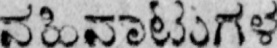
ವಹಿವಾಟುಗಳ
